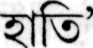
হাতি’
